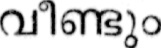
വീണ്ടും
